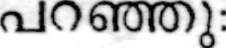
പറഞ്ഞു:
